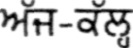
ਅੱਜ-ਕੱਲ੍ਹ
